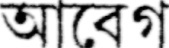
আবেগ
